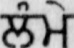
ਲੰਮੇ
